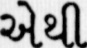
એથી
